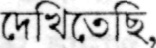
দেখিতেছি,
